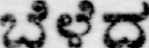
ಬೆಳೆದ
